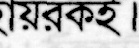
হায়রকই
